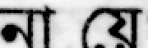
তাঙনা
